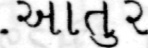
આતુર
